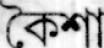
কৈশা
